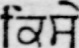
ਕਿਸੇ
